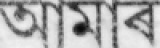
আমাৰ
